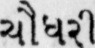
ચૌધરી
